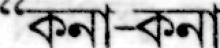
“কনা-কনা
